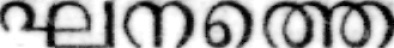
ഘനത്തെ
